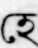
হে
